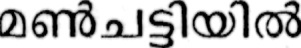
മണ്‍ചട്ടിയില്‍
